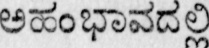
ಅಹಂಭಾವದಲ್ಲಿ
